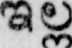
ಇಲ್ಲ
